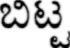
ಬಿಟ್ಟ
